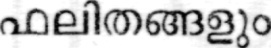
ഫലിതങ്ങളും
